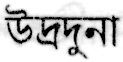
উদ্রদুনা
